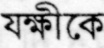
যক্ষীকে
